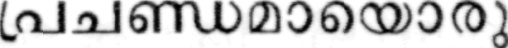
പ്രചണ്ഡമായൊരു
